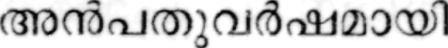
അന്‍പതുവര്‍ഷമായി
